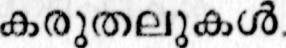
കരുതലുകള്‍.
